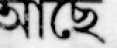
আছে
